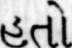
હતો
